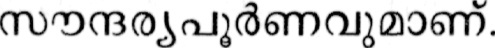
സൌന്ദര്യപൂര്‍ണവുമാണ്.
